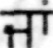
ਜਾਂ
